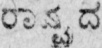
ರಾಷ್ಟ್ರದ
